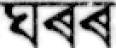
ঘৰৰ
